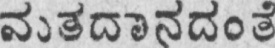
ಮತದಾನದಂತೆ
